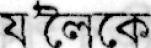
য'লৈকে
